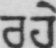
ਰਹੇ
